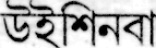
উইশিনবা
